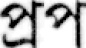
প্রপ
